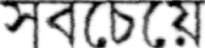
সবচেয়ে
